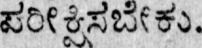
ಪರೀಕ್ಷಿಸಬೇಕು.
